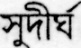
সুদীর্ঘ
